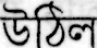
উঠিল
